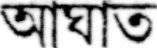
আঘাত
